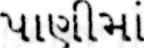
પાણીમાં
